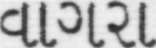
વાગરા
